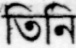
তিনি
